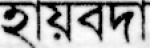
হায়বদা
